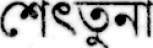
শেৎতুনা
